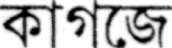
কাগজে
